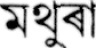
মথুৰা
